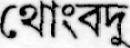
থোংবদু
